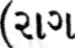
(રાગ
